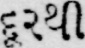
દૂરથી
